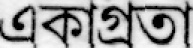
একাগ্রতা
